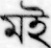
মই
